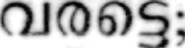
വരട്ടെ;
